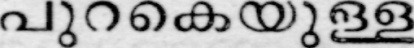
പുറകെയുള്ള
